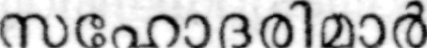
സഹോദരിമാര്‍
